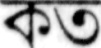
কত
